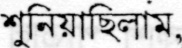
শুনিয়াছিলাম,
